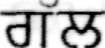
ਗੱਲ
